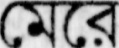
মেরে
